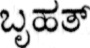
ಬೃಹತ್
